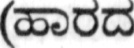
(ಹಾರದ
